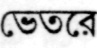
ভেতরে
